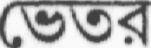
ভেতর
